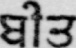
ਬੀਤ
